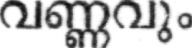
വണ്ണവും
